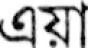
এয়া
